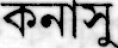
কনাসু
